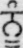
ਨੂੰ
